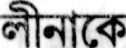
লীনাকে
